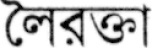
লৈরক্তা
